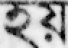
হয়
